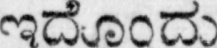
ಇದೊಂದು
